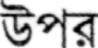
উপর
